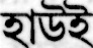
হাউই
